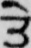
ਤੇ
